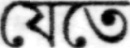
যেতে
